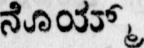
ನೊಯ್ಮ್
